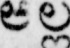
ಅಲ್ಲ
